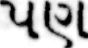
પણ
